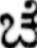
ಚೆ
